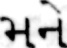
મને
